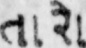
તારો
